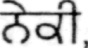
ਨੇਕੀ,
